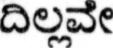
ದಿಲ್ಲವೇ
